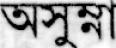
অসুম্না
